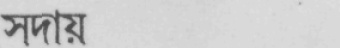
সদায়
